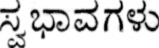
ಸ್ವಭಾವಗಳು
